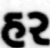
હર
